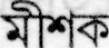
মীশগক
